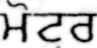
ਮੋਟਰ
